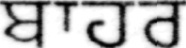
ਬਾਹਰ
